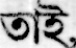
তাই,
